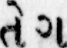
તેગ
